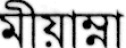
মীয়াম্না
